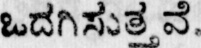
ಒದಗಿಸುತ್ತವೆ.
